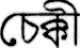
চেক্কী
